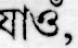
যাওঁ,
